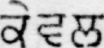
ਕੇਵਲ
